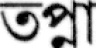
তপ্না
